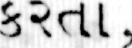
કરતા,
